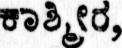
ಕಾಶ್ಮೀರ,
